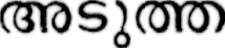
അടുത്ത
